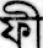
ফী
